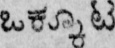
ಒಕ್ಕೂಟ
